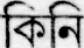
কিনি
